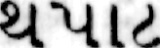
થપાટ
